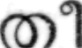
തീ
